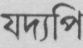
যদ্যপি
